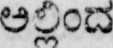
ಅಲ್ಲಿಂದ
